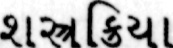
શસ્ત્રક્રિયા
